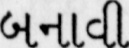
બનાવી
